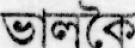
ভালকৈ
